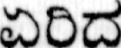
ಏರಿದ
